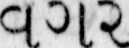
વગર
